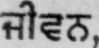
ਜੀਵਨ,
